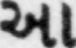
આ
